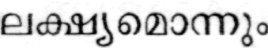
ലക്ഷ്യമൊന്നും
